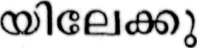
യിലേക്കു
